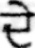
ਦੇ
